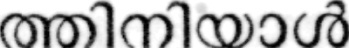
ത്തിനിയാള്‍
